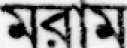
মরাম
